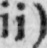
ii)
